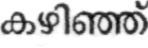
കഴിഞ്ഞ്
